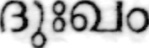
ദുഃഖം
